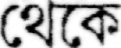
থেকে
